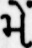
મેં
